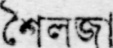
শৈলজা
